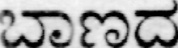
ಬಾಣದ
